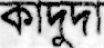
কাদুদা
